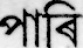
পাৰি
